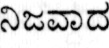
ನಿಜವಾದ
